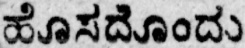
ಹೊಸದೊಂದು
